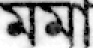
মমা
